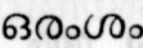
ഒരംശം
